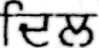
ਦਿਲ
